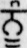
ਨੂੰ
